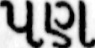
પણ
